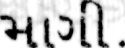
માગી.
